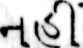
નહીં
